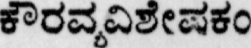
ಕೌರವ್ಯವಿಶೇಷಕಂ
